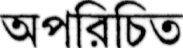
অপরিচিত
